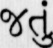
જતું
